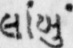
લાંબું
